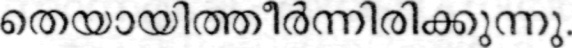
തെയായിത്തീര്‍ന്നിരിക്കുന്നു.
